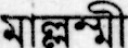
মাল্লম্মী
